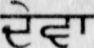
ਦੇਵਾ
